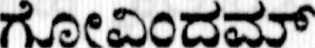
ಗೋವಿಂದಮ್
